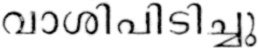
വാശിപിടിച്ചു
